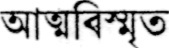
আত্মবিস্মৃত
